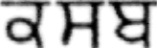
ਕਸਬ
